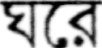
ঘরে
